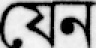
যেন
